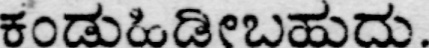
ಕಂಡುಹಿಡೀಬಹುದು.
